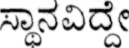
ಸ್ಥಾನವಿದ್ದೇ
